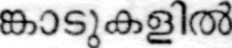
ങ്കാടുകളില്‍
